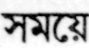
সময়ে
